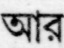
আর
